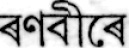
ৰণবীৰে
